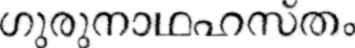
ഗുരുനാഥഹസ്തം
